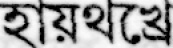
হায়থখ্রে
